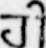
ਹੀ
